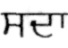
ਸਦਾ
